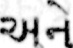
અને
